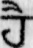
ਹੈ
